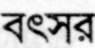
বত্সর
